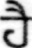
ਹੈ
